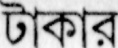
টাকার
